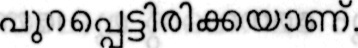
പുറപ്പെട്ടിരിക്കയാണ്.
